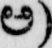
ಅ)
